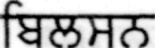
ਬਿਲਸਨ
